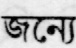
জন্যে
